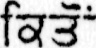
ਕਿਤੋਂ
